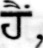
ਹੈਂ,
